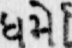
ધર્મો
